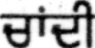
ਚਾਂਦੀ
